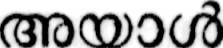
അയാള്‍
